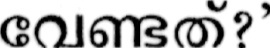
വേണ്ടത്?’
